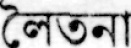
লৈতনা
